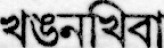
খঙনখিবা
